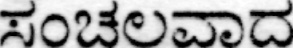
ಸಂಚಲವಾದ
